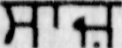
ਸਾਜ਼
